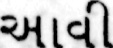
આવી
